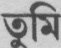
তুমি
